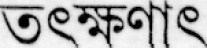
তৎক্ষণাৎ
